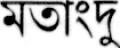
মতাংদু
